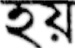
হয়
